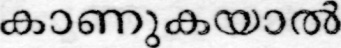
കാണുകയാല്‍
